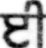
ਈ
